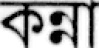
কন্না
